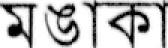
মঙাকা
